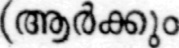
(ആര്‍ക്കും
